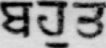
ਬਹੁਤ
